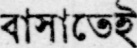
বাসাতেই
